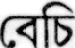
বেচি
